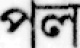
পল
